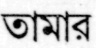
তামার
